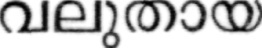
വലുതായ
